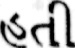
હતી
